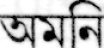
অমনি
